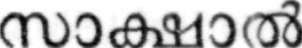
സാക്ഷാല്‍
